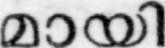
മായി
